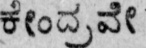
ಕೇಂದ್ರವೇ
